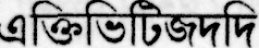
এক্তিভিটিজদদি
